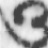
ও
